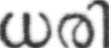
ധരി
